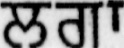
ਲਗਾ
